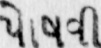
પોષવી
